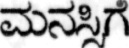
ಮನಸ್ಸಿಗೆ
